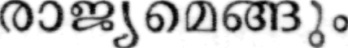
രാജ്യമെങ്ങും
